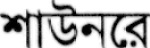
শাউনরে
